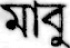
মাবু
